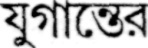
যুগান্তের
